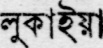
লুকাইয়া
